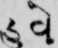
હવે
